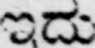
ಇದು
